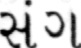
સંગ
